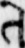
તે
